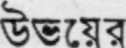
উভয়ের
